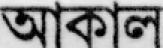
আকাল
